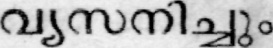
വ്യസനിച്ചും
